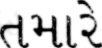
તમારે
